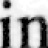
in
